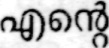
എന്റെ
